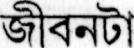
জীবনটা
